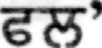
ਫਲ'
